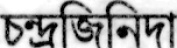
চন্দ্রজিনিদা
